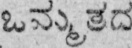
ಒಮ್ಮತದ
